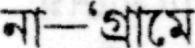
না—‘গ্রামে
